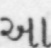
આ
